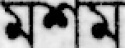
মশম
